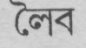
লৈব
